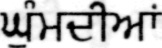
ਘੁੰਮਦੀਆਂ
